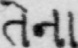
તેના
